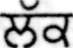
ਲੱਕ
